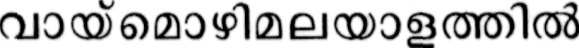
വായ്മൊഴിമലയാളത്തില്‍
